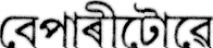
বেপাৰীটোৱে
